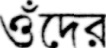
ওঁদের
